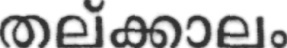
തല്ക്കാലം
